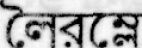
লৈরম্লে
